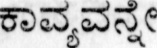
ಕಾವ್ಯವನ್ನೇ
